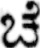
ಚೆ
